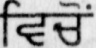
ਵਿਚੋਂ
